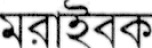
মরাইবক
